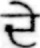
ਦੇ
